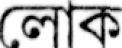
লোক
